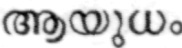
ആയുധം
